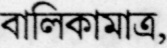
বালিকামাত্র,
